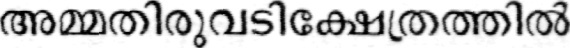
അമ്മതിരുവടിക്ഷേത്രത്തില്‍
